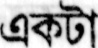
একটা
